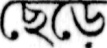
ছেড়ে
